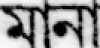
মানা
